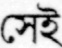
সেই
